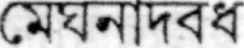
মেঘনাদবধ
